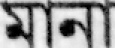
মানা
